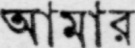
আমার
